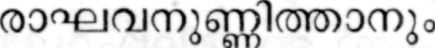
രാഘവനുണ്ണിത്താനും
